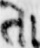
તો
